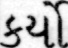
કર્યો
